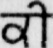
ਕੀ
